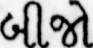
બીજો
